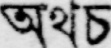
অথচ
